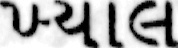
ખ્યાલ
